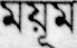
ময়ূম
